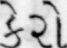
કેરો
